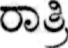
ರಾತ್ರಿ
